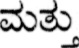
ಮತ್ತು
